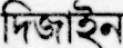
দিজাইন
